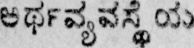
ಅರ್ಥವ್ಯವಸ್ಥೆಯ
